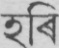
হৰি
